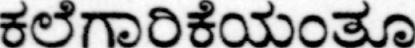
ಕಲೆಗಾರಿಕೆಯಂತೂ
